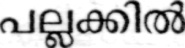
പല്ലക്കില്‍
